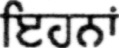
ਇਹਨਾਂ
